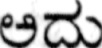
ಅದು
